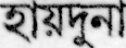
হায়দুনা
